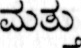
ಮತ್ತು
